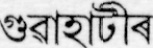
গুৱাহাটীৰ
